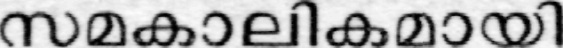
സമകാലികമായി
